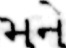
મને
